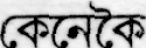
কেনেকৈ
